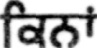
ਕਿਨਾਂ
